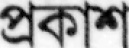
প্রকাশ
